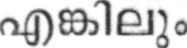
എങ്കിലും
